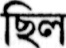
ছিল
